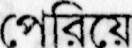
পেরিয়ে
